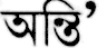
‘অন্তি’
